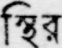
স্থির
